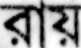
রায়
